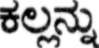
ಕಲ್ಲನ್ನು
